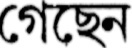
গেছেন
